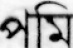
পমি
